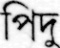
পিদু
